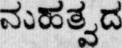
ಮಹತ್ವದ
